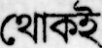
থোকই
